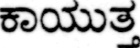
ಕಾಯುತ್ತ
